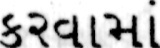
કરવામાં
